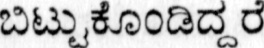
ಬಿಟ್ಟುಕೊಂಡಿದ್ದರೆ
